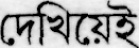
দেখিয়েই
